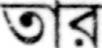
তার
